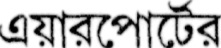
এয়ারপোর্টের
